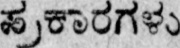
ಪ್ರಕಾರಗಳು
